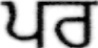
ਪਰ
